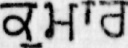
ਕੁਮਾਰ
